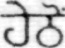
ਹੇਠੋਂ
